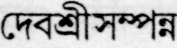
দেবশ্রীসম্পন্ন
